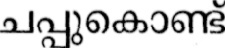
ചപ്പുകൊണ്ട്
